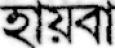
হায়বা
